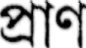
প্রাণ
